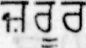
ਜ਼ਰੂਰ
